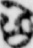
છે
